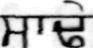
ਸਾਢੇ
